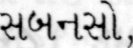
સબનસો,
